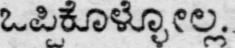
ಒಪ್ಪಿಕೊಳ್ಳೋಲ್ಲ.
